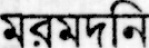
মরমদনি
